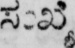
ಸಂಖ್ಯೆ
